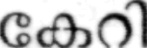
കേറി
